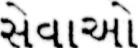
સેવાઓ
